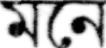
মনে
